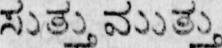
ಸುತ್ತುಮುತ್ತು
